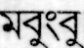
মবুংবু
